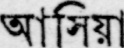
আসিয়া
